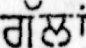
ਗੱਲਾਂ
